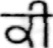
ਕੀ
